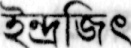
ইন্দ্রজিৎ
